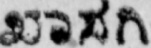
ಖಾಸಗಿ
